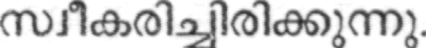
സ്വീകരിച്ചിരിക്കുന്നു.
